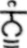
ਨੂੰ
